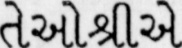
તેઓશ્રીએ
